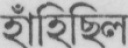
হাঁহিছিল
